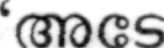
'അടേ
